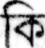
কি
